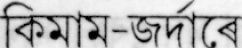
কিমাম-জর্দাৰে
